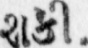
શકી.
